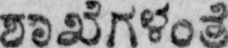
ಶಾಖೆಗಳಂತೆ
